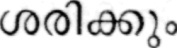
ശരിക്കും
